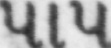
પાપ
